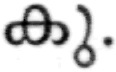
കു.
